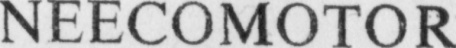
NEECOMOTOR
